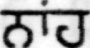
ਨਾਂਹ
